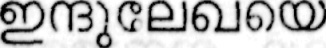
ഇന്ദുലേഖയെ
